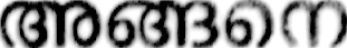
അങ്ങനെ
